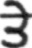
ਤੇ
